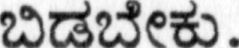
ಬಿಡಬೇಕು.
